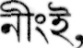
নীংই,
